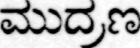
ಮುದ್ರಣ
